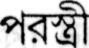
পরস্ত্রী
